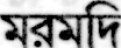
মরমদি
